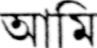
আমি
